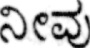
ನೀವು
